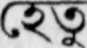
হেতু
